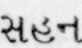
સહન
